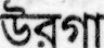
উরগা
